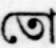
তো
